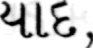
યાદ,
